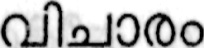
വിചാരം
